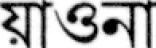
য়াওনা
